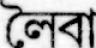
লৈবা
